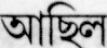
আছিল
